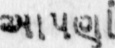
આપણાં
